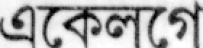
একেলগে
